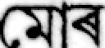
মোৰ
